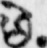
આ
